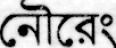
নৌরেং
